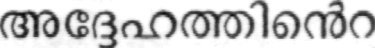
അദ്ദേഹത്തിന്റെ
